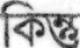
কিন্তু
